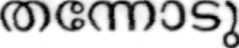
തന്നോടു
